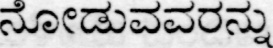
ನೋಡುವವರನ್ನು
